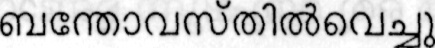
ബന്തോവസ്തില്‍വെച്ചു
